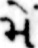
મેં
